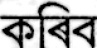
কৰিব
